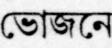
ভোজনে
